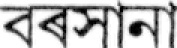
বৰসানা
